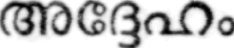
അദ്ദേഹം
